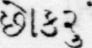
છોકરું
